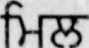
ਮਿਲ
